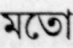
মতো
